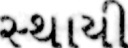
સ્થાયી
